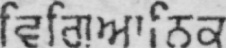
ਵਿਗਿਆਨਿਕ
